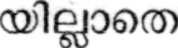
യില്ലാതെ
